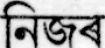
নিজৰ
